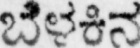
ಬೆಳಕಿನ
